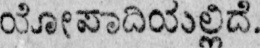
ಯೋಪಾದಿಯಲ್ಲಿದೆ.
